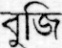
বুজি
